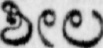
ಶೀಲ
